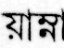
য়াম্না
